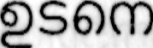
ഉടനെ
